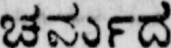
ಚರ್ಮದ
